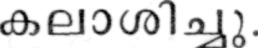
കലാശിച്ചു.
